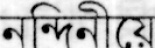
নন্দিনীয়ে
